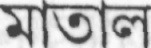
মাতাল
